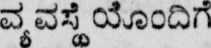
ವ್ಯವಸ್ಥೆಯೊಂದಿಗೆ
